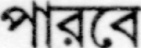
পারবে
